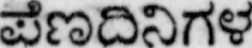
ಪೆಣದಿನಿಗಳ
